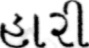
હારી
